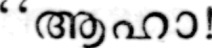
"ആഹാ!
